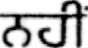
ਨਹੀਂ
